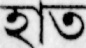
হাত
